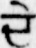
ਦੇ
